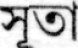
সূতা
